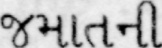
જમાતની
